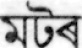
মটৰ
